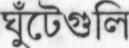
ঘুঁটেগুলি
